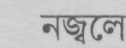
নজ্বলে
